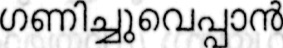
ഗണിച്ചുവെപ്പാന്‍
